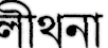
লীথনা
